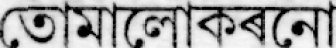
তোমালোকৰনো
